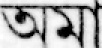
অমা
